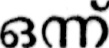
ഒന്ന്
